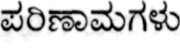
ಪರಿಣಾಮಗಳು
